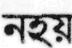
নহয়
